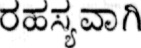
ರಹಸ್ಯವಾಗಿ
